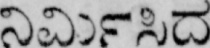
ನಿರ್ಮಿಸಿದ
